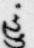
હું
